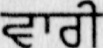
ਵਾਰੀ
